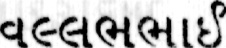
વલ્લભભાઈ
